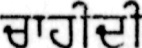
ਚਾਹੀਦੀ
